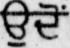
ਉਦੋਂ
